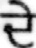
ਦੇ
